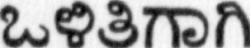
ಒಳಿತಿಗಾಗಿ
